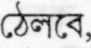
ঠেলবে,
